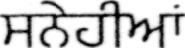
ਸਨੇਹੀਆਂ
